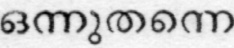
ഒന്നുതന്നെ
